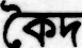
কৈদ
